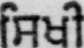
ਸਿਖੀ
